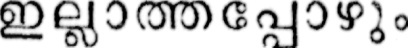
ഇല്ലാത്തപ്പോഴും
